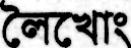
লৈখোং
